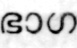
ഭാഗ
